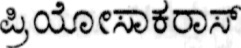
ಪ್ರಿಯೋಸಾಕರಾಸ್
